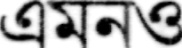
এমনও
